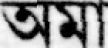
অমা
